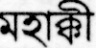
মহাক্কী
